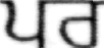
ਪਰ
